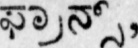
ಫ್ರಾನ್ಸ್,
